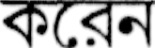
করেন
